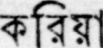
করিয়া
